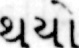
થયો
